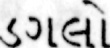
ડગલો
